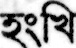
হংখি
